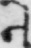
ને
